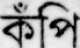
কঁপি
